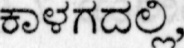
ಕಾಳಗದಲ್ಲಿ,
